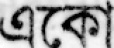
একো
